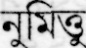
নুমিত্তু
